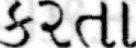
કરતા
